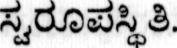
ಸ್ವರೂಪಸ್ಥಿತಿ.
